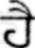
ਹੈ
